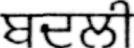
ਬਦਲੀ
